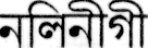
নলিনীগী
